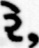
રે,
